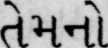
તેમનો
